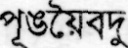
পূঙয়ৈবদু
